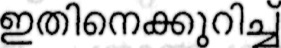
ഇതിനെക്കുറിച്ച്
